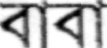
বাবা
